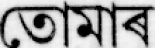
তোমাৰ
